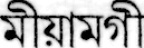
মীয়ামগী
